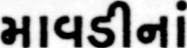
માવડીનાં
